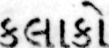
કલાકો
